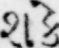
શકે
